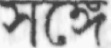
সঙ্গে
